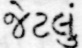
જેટલું
